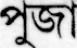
পুজা
